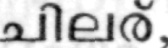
ചിലര്,
